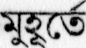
মুহূর্তে
